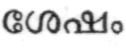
ശേഷം
